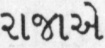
રાજાએ
